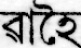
ৱাহৈ
